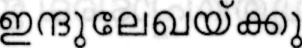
ഇന്ദുലേഖയ്ക്കു
